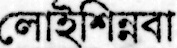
লোইশিন্নবা
